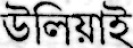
উলিয়াই
